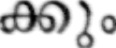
ക്കും
